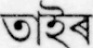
তাইৰ
